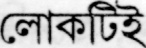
লোকটিই
